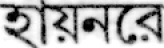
হায়নরে
